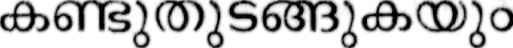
കണ്ടുതുടങ്ങുകയും
